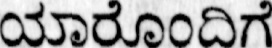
ಯಾರೊಂದಿಗೆ
